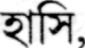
হাসি,
